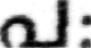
പ:
